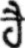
ਹੈ
